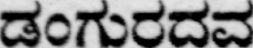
ಡಂಗುರದವ
